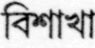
বিশাখা
